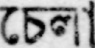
চেলা
